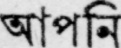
আপনি
